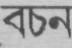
বচন
